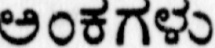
ಅಂಕಗಳು
